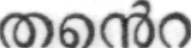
തന്റെ
